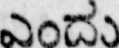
ಎಂದು
